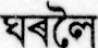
ঘৰলৈ
